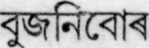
বুজনিবোৰ
